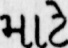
માટે
